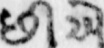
છીએ
